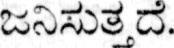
ಜನಿಸುತ್ತದೆ.
